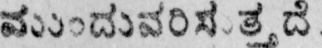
ಮುಂದುವರಿಸುತ್ತದೆ
